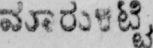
ಮಾರುಕಟ್ಟೆ
